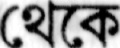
থেকে
